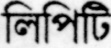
লিপিটি
